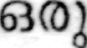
ഒരു
